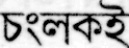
চংলকই
